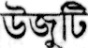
উজুটি
